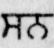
ਸਨ
